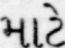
માટે
